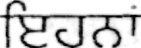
ਇਹਨਾਂ
